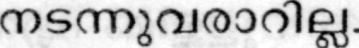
നടന്നുവരാറില്ല.
